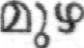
മുഴ
